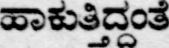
ಹಾಕುತ್ತಿದ್ದಂತೆ
